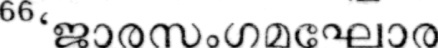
66'ജാരസംഗമഘോര
